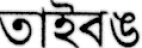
তাইবঙ
